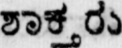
ಶಾಕ್ತರು
